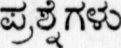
ಪ್ರಶ್ನೆಗಳು
